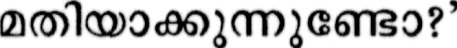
മതിയാക്കുന്നുണ്ടോ?’
